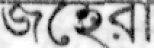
জহেরা
